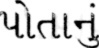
પોતાનું
